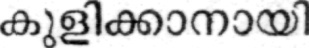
കുളിക്കാനായി
